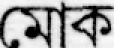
মোক
